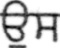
ਉਸ
